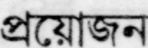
প্রয়োজন
